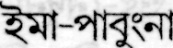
ইমা-পাবুংনা
